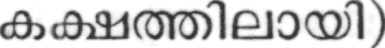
കക്ഷത്തിലായി)
